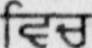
ਵਿਚ
